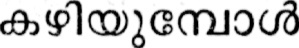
കഴിയുമ്പോള്‍
